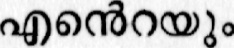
എന്റെയും
